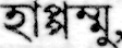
হাপ্পম্মু,
